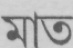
মাত
